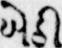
બેઠી
